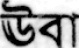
ঊবা
